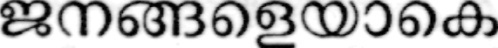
ജനങ്ങളെയാകെ
